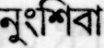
নুংশিবা
